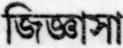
জিজ্ঞাসা
